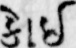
કોઈ
